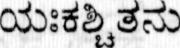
ಯಃಕಶ್ಚಿತನು
